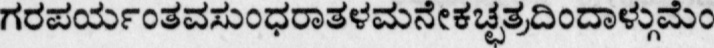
ಗರಪರ್ಯಂತವಸುಂಧರಾತಳಮನೇಕಚ್ಛತ್ರದಿಂದಾಳ್ಗುಮೆಂ
